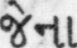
જેના
